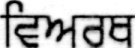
ਵਿਅਰਥ
